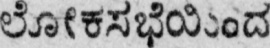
ಲೋಕಸಭೆಯಿಂದ
